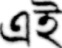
এই
